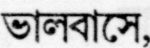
ভালবাসে,
